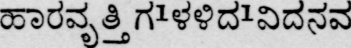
ಹಾರವೃತ್ತಿಗ1ಳಳಿದ1ನಿದನವ
